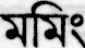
মমি
